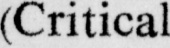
(Critical
